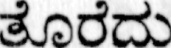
ತೊರೆದು
